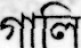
গালি
